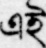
এই
